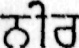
ਨੀਰ
